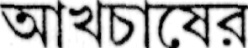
আখচাষের
